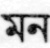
মন
